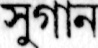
সুগান
